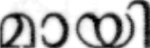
മായി
